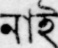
নাই
